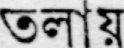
তলায়
